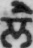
ਲੈ
